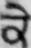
ਕੇ
